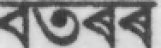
বতৰৰ
